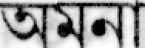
অমনা
